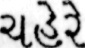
ચહેરે
